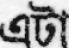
এটা
